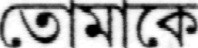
তোমাকে
